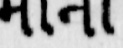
માના
